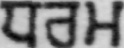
ਧਰਮ
